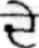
ਦੇ
